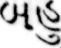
બહુ
